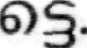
ട്ടെ.
